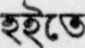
হইতে
